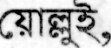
য়োল্লুই,
